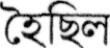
হৈছিল
